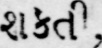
શકતી,
